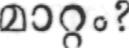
മാറ്റം?
